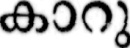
കാറു
